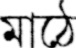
মাঠে
